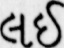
લઈ
